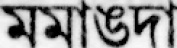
মমাঙদা
